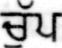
ਚੁੱਪ
